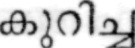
കുറിച്ച
